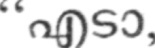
"എടാ,
